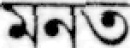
মনত
